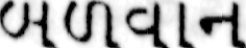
બળવાન
